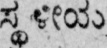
ಸ್ಥಳೀಯ
